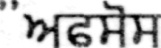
''ਅਫਸੋਸ
